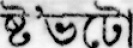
ষ্ট'ভটো
